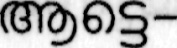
ആട്ടെ-
